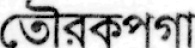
তৌরকপগা
